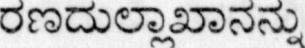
ರಣದುಲ್ಲಾಖಾನನ್ನು
